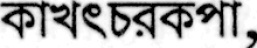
কাখৎচরকপা,
